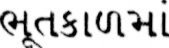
ભૂતકાળમાં
